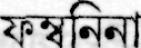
ফম্বনিনা
